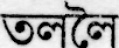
তললৈ
